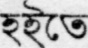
হইতে
